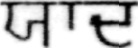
ਯਾਦ
